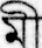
মী
